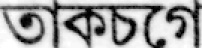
তাকচগে
